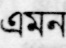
এমন
